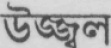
উজ্জ্বল
